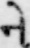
ને
